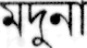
মদুনা
